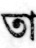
তা
